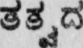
ತತ್ವದ
